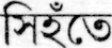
সিহঁতে
